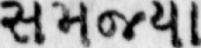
સમજ્યા
